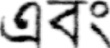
এবং
